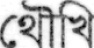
থৌখি
